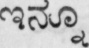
ಇನ್ನೂ
